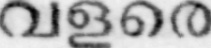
വളരെ
